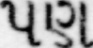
પણ
